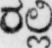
ರಲ್ಲಿ
